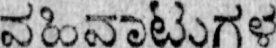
ವಹಿವಾಟುಗಳ
